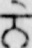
ਨੇ
